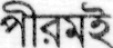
পীরমই
